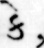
કે,
